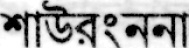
শাউরংননা
